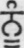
ਨੂੰ
